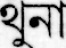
থুনা
